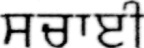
ਸਚਾਈ
